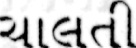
ચાલતી
